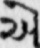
એ
